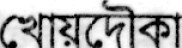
খোয়দৌকা
